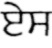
ਏਸ
